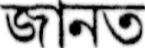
জানত
